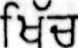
ਖਿੱਚ
